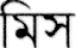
মিস
